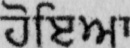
ਹੋਇਆ
